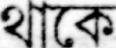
থাকে
